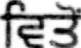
ਵਿਤੋਂ
